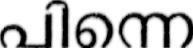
പിന്നെ
